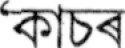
'কাচৰ
